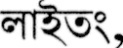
লাইতং,
